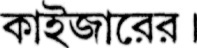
কাইজারের।
